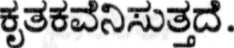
ಕೃತಕವೆನಿಸುತ್ತದೆ.
